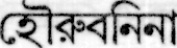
হৌরুবনিনা
